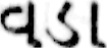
વડા
